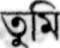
তুমি
